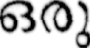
ഒരു
